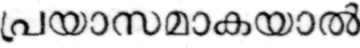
പ്രയാസമാകയാല്‍
